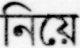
নিয়ে
